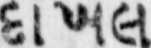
દાખલ
